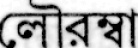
লৌরম্বা
